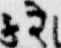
કરો
